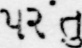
પરંતુ
